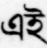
এই
